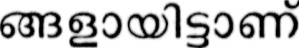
ങ്ങളായിട്ടാണ്
